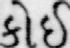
કોઈ
